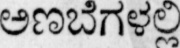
ಅಣಬೆಗಳಲ್ಲಿ
